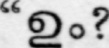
“ഉം?
